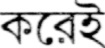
করেই
